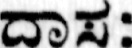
ದಾಸ:
